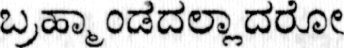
ಬ್ರಹ್ಮಾಂಡದಲ್ಲಾದರೋ
